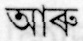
আৰু
